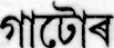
গাটোৰ
